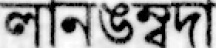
লানঙম্বদা
